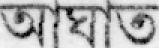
আঘাত
